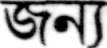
জন্য
